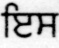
ਇਸ
